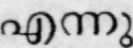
എന്നു
